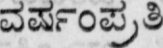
ವರ್ಷಂಪ್ರತಿ
